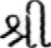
શ્રી
